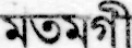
মতমগী
